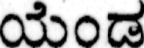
ಯೆಂಡ
